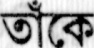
তাঁকে
